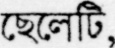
ছেলেটি,
